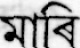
মাৰি
